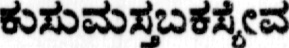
ಕುಸುಮಸ್ತಬಕಸ್ಯೇವ
